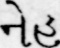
નેહ
